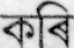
কৰি
